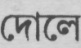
দোলে
